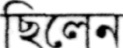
ছিলেন
